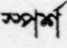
স্পর্শ
